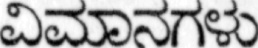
ವಿಮಾನಗಳು
